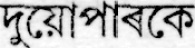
দুয়োপাৰকে
